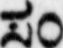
ಸಂ
